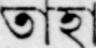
তাহা
